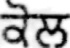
ਕੋਲ
